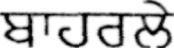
ਬਾਹਰਲੇ
